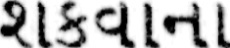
શકવાના
